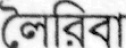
লৈরিবা
